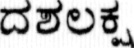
ದಶಲಕ್ಷ
